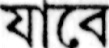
যাবে
